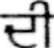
ਦੀ
